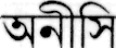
অনীসি
